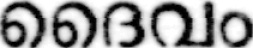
ദൈവം
